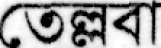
তেল্লবা
